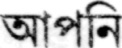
আপনি
